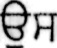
ਉਸ
